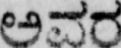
ಅವರ
